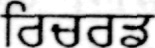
ਰਿਚਰਡ
